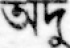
অদু
